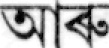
আৰু
